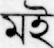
মই
